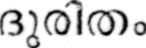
ദുരിതം
